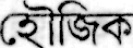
হৌজিক
